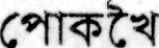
পোকখৈ
